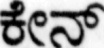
ಕೇನ್
